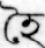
হৈ
